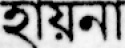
হায়না
